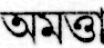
অমত্তা
